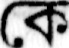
কে
